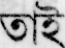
তাই
